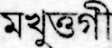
মখুত্তগী
